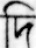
দি
